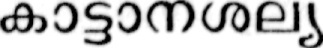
കാട്ടാനശല്യ
